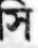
সি
